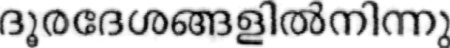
ദൂരദേശങ്ങളില്‍നിന്നു
